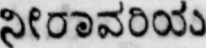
ನೀರಾವರಿಯ
